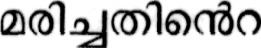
മരിച്ചതിന്റെ
